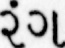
રંગ
